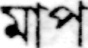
মাপ
